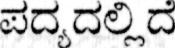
ಪದ್ಯದಲ್ಲಿದೆ
